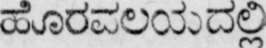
ಹೊರವಲಯದಲ್ಲಿ
